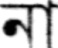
না
